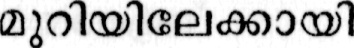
മുറിയിലേക്കായി
